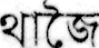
থাজৈ
